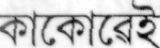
কাকোৱেই
